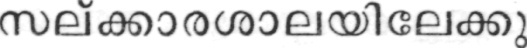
സല്ക്കാരശാലയിലേക്കു
